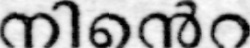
നിന്റെ
